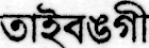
তাইবঙগী
